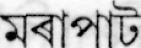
মৰাপাট
